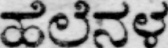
ಹೆಲೆನಳ
